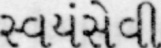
સ્વયંસેવી
